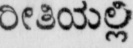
ರೀತಿಯಲ್ಲಿ
